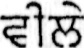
ਵੀਲੇ
